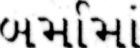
બર્મામાં
